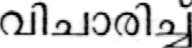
വിചാരിച്ച്
